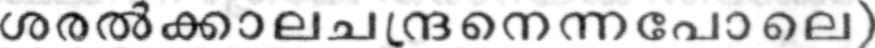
ശരല്‍ക്കാലചന്ദ്രനെന്നപോലെ)
